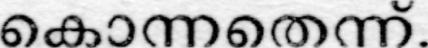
കൊന്നതെന്ന്.
